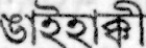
ঙাইহাক্কী
